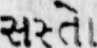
સસ્તો
